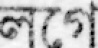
লগে
